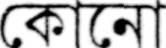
কোনো
